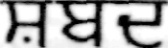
ਸ਼ਬਦ
